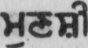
ਮੁਣਸ਼ੀ
